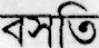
বসতি
